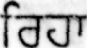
ਰਿਹਾ
